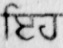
ਇਹ
